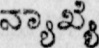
ವ್ಯಾಖ್ಯೆ
